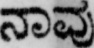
ನಾವು
